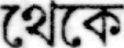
থেকে
